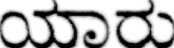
ಯಾರು
